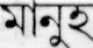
মানুহ
